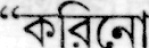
“করিনো
